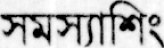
সমস্যাশিং
